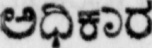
ಅಧಿಕಾರ
